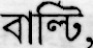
বাল্টি,
